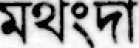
মথংদা
